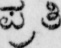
ಪ್ರತಿ
